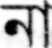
না
